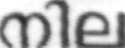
നില
